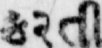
કરતી
